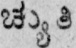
ಚ್ಯುತಿ
